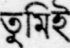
তুমিই
